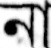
না
